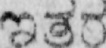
ಇತರ
